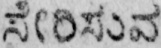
ಸೇರಿಸುವ
